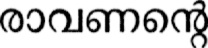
രാവണന്റെ
